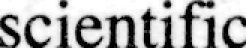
scientific
